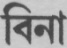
বিনা
